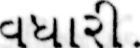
વધારી.
